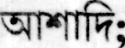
আশাদি;
